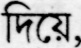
দিয়ে,
